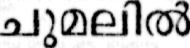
ചുമലില്‍
